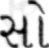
સો
